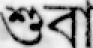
শুবা
